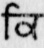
ਕਿ
